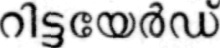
റിട്ടയേര്‍ഡ്
